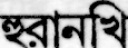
হুরানখি
